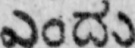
ಎಂದು
